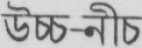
উচ্চ-নীচ
